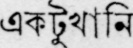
একটুখানি
